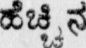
ಹೆಚ್ಚಿನ
